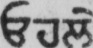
ਓਹਲੇ
